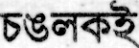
চঙলকই
